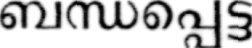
ബന്ധപ്പെട്ട
